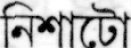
নিশাটো
